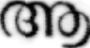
ആ
